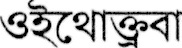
ওইথোক্ত্রবা
